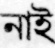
নাই
